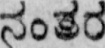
ನಂತರ
